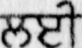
ਲਈ
